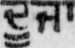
ਦੂਜਾ
